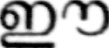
ഈ
